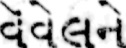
વૅવેલને
